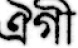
ঐগী
